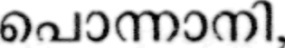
പൊന്നാനി,
